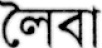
লৈবা
